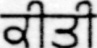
ਕੀਤੀ
